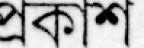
প্রকাশ
